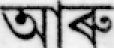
আৰু
